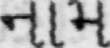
નામ
